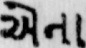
એના
